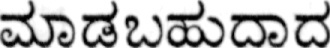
ಮಾಡಬಹುದಾದ
